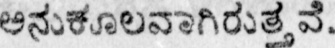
ಅನುಕೂಲವಾಗಿರುತ್ತವೆ.
